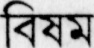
বিষম
